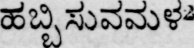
ಹಬ್ಬಿಸುವಮಳ2
